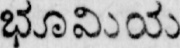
ಭೂಮಿಯ
